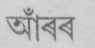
আঁৰৰ
